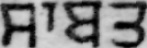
ਸਾਬਤ
